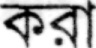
করা
